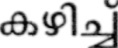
കഴിച്ച്
